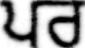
ਪਰ
